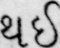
થઈ
